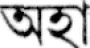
অহা
